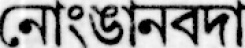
নোংঙানবদা
